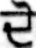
ਦੋ
